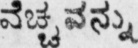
ವೆಚ್ಚವನ್ನು
